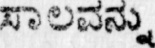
ಸಾಲವನ್ನು
